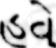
હવે
